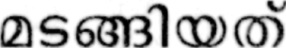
മടങ്ങിയത്
